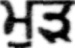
ਮੁੜ
